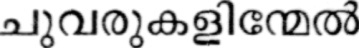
ചുവരുകളിന്മേല്‍
